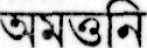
অমত্তনি
